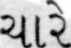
ચારે
